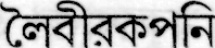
লৈবীরকপনি
